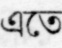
এতে
